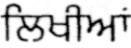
ਲਿਖੀਆਂ
